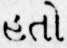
હતો
